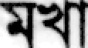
মখা
